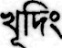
খূদিং
